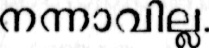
നന്നാവില്ല.
